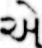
એ
